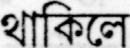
থাকিলে
